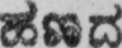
ಹಣದ
